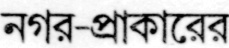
নগর-প্রাকারের
